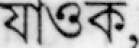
যাওক,
